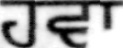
ਹਵਾ
